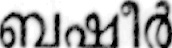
ബഷീര്‍
